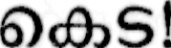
കെട!
